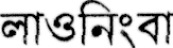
লাওনিংবা
